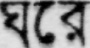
ঘরে
